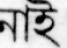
নাই
